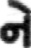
ને
